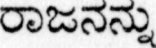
ರಾಜನನ್ನು
